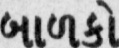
બાળકો
